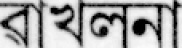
ৱাখলনা
